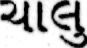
ચાલુ
